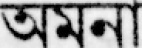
অমনা
